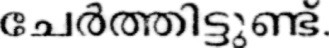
ചേര്‍ത്തിട്ടുണ്ട്.
